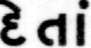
દેતાં
